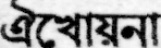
ঐখোয়না
